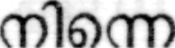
നിന്നെ
